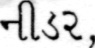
નીડર,
